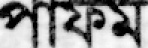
পাফম
